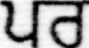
ਪਰ
